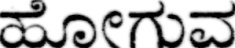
ಹೋಗುವ
